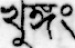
খুঙ্গং
